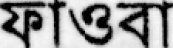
ফাওবা
